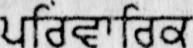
ਪਰਿਵਾਰਿਕ
